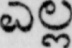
ಎಲ್ಲ
